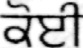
ਕੋਈ
